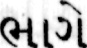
ભાગે
